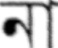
না
